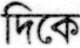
দিকে
